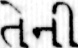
તેની
